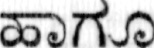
ಹಾಗೂ
